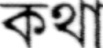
কথা
